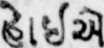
હોઈએ
